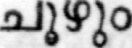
ചൂഴും
